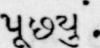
પૂછ્યું.
